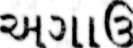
અગાઉ
